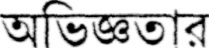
অভিজ্ঞতার
